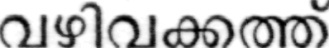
വഴിവക്കത്ത്
